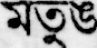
মতুঙ
